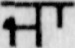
ਜਾ
